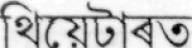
থিয়েটাৰত
